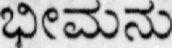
ಭೀಮನು
